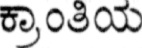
ಕ್ರಾಂತಿಯ
